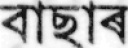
বাছাৰ
